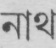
নাথ
